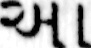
આ
